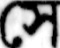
সে
